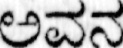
ಅವನ
